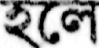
হলে
